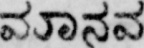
ಮಾನವ
